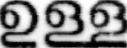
ഉള്ള
